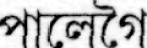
পালেগৈ
